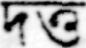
দত্ত
